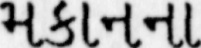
મકાનના
